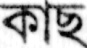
কাছ
